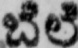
ಬೆಲೆ
